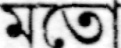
মতো
